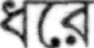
ধরে
